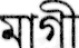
মাগী
